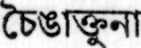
চৈঙাক্তুনা
